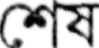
শেষ
